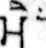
ਮੈਂ
